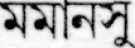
মমানসু
